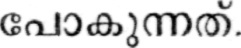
പോകുന്നത്.
